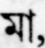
মা,
